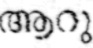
ആറു
